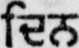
ਦਿਨ
